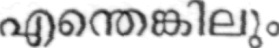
എന്തെങ്കിലും
